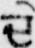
ਦੇ
